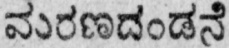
ಮರಣದಂಡನೆ
